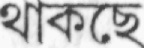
থাকছে
